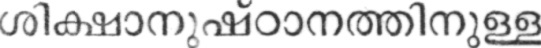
ശിക്ഷാനുഷ്ഠാനത്തിനുള്ള
